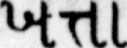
ખત્તા
